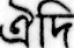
ঐদি
